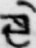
ਦੇ
